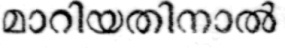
മാറിയതിനാല്‍
